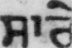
ਸਾਰੇ
